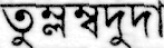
তুম্লম্বদুদা
